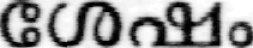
ശേഷം
